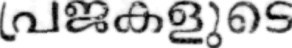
പ്രജകളുടെ
